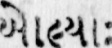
બોલ્યાઃ
